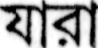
যারা
